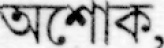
অশোক,
